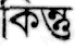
কিন্তু
